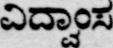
ವಿದ್ವಾಂಸ
